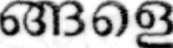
ങ്ങളെ
